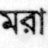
মরা
